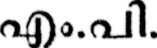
എം.പി.
